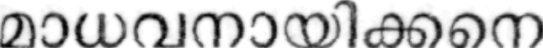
മാധവനായിക്കനെ
